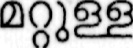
മറ്റുള്ള
